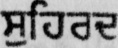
ਸੁਹਿਰਦ
